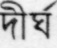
দীর্ঘ
